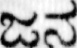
ಜನ
